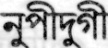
নুপীদুগী
